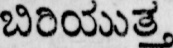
ಬಿರಿಯುತ್ತ
